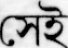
সেই
